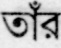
তাঁর
